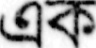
এক
